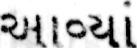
આવ્યાં
